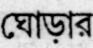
ঘোড়ার
